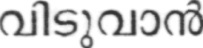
വിടുവാന്‍
